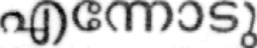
എന്നോടു
